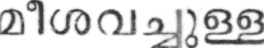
മീശവച്ചുള്ള
